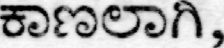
ಕಾಣಲಾಗಿ,
